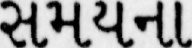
સમયના
